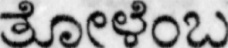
ತೋಳೆಂಬ
